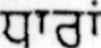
ਧਾਰਾਂ
